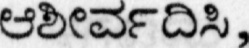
ಆಶೀರ್ವದಿಸಿ,
